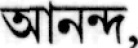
আনন্দ,
